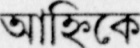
আহ্নিকে
